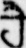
ਹੈ
